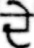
ਦੇ
